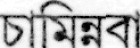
চামিন্নবা
